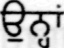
ਉਨ੍ਹਾਂ
